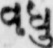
વધુ
